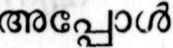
അപ്പോള്‍
